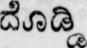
ದೊಡ್ದಿ
